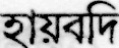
হায়বদি
